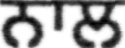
ਨਾਲ
